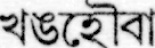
খঙহৌবা
